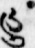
હું
